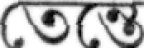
তেন্তে
